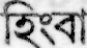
হিংবা
